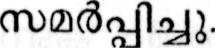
സമര്‍പ്പിച്ചു.
